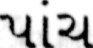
પાંચ
